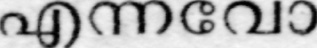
എന്നവോ
